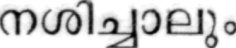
നശിച്ചാലും
